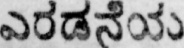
ಎರಡನೆಯ
